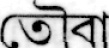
তৌবা
